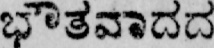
ಭೌತವಾದದ
